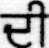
ਦੀ
